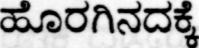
ಹೊರಗಿನದಕ್ಕೆ
